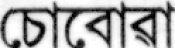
চোবোৱা
